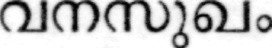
വനസുഖം
